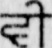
ਵੀ
